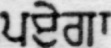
ਪਏਗਾ
